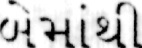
બેમાંથી
